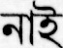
নাই
